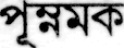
পূম্নমক
